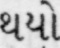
થયો
